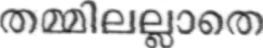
തമ്മിലല്ലാതെ
